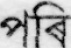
পৰি
